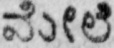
ಮೇಲೆ
